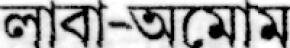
লাবা-অমোম
